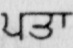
ਪਤਾ
